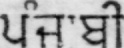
ਪੰਜਾਬੀ
